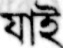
যাই
